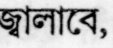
জ্বালাবে,
